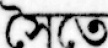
সৈতে
